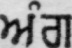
ਅੰਗ
